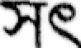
সৎ
